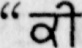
''ਕੀ
